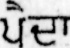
ਪੈਦਾ
